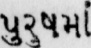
પુરુષમાં
